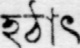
হঠাৎ
